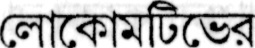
লোকোমটিভের
